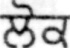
ਲੋਕ
